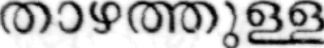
താഴത്തുള്ള
